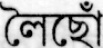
লৈছোঁ
